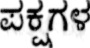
ಪಕ್ಷಗಳ
